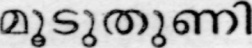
മൂടുതുണി
